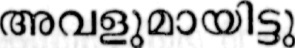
അവളുമായിട്ടു
